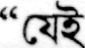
"যেই
